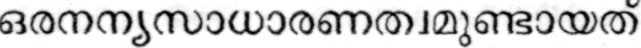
ഒരനന്യസാധാരണത്വമുണ്ടായത്
